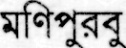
মণিপুরবু
